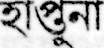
হাপ্তুনা
